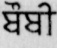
ਬੌਬੀ
